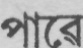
পাৱে
